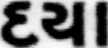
દયા
